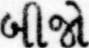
બીજો
